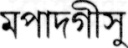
মপাদগীসু
